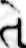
તે
